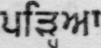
ਪੜ੍ਹਿਆ
